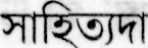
সাহিত্যদা
